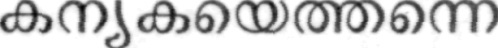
കന്യകയെത്തന്നെ
